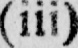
(iii)
